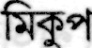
মিকুপ
